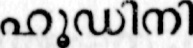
ഹൂഡിനി
